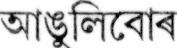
আঙুলিবোৰ
